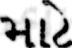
માટે
